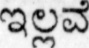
ಇಲ್ಲವೆ
